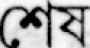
শেষ
